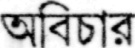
অবিচার
